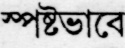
স্পষ্টভাবে
